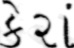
કેરાં
